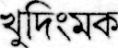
খুদিংমক
